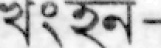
খংহন-
